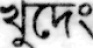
খুদেং
